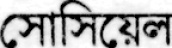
সোসিয়েল
